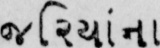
જરિયાંના
